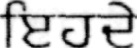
ਇਹਦੇ
